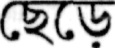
ছেড়ে
